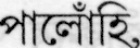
পালোঁহি,
